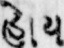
હોય
